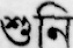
শুনি
